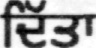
ਦਿੱਤਾ
